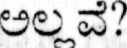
ಅಲ್ಲವೆ?
